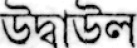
উদ্বাউল
